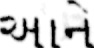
આને
